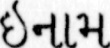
ઇનામ
